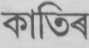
কাতিৰ
